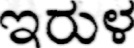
ಇರುಳ
